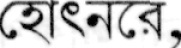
হোৎনরে,
